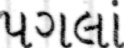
પગલાં
